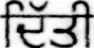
ਦਿੱਤੀ
